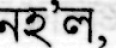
নহ'ল,
